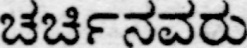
ಚರ್ಚಿನವರು
